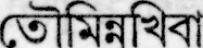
তৌমিন্নখিবা
